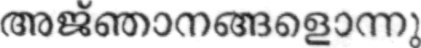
അജ്ഞാനങ്ങളൊന്നു
